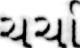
ચર્ચા
